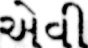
એવી
